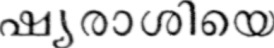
ഷ്യരാശിയെ
